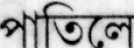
পাতিলে
